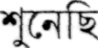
শুনেছি
